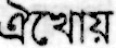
ঐখোয়
